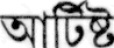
আৰ্টিষ্ট
